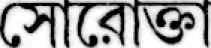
সোরোক্তা
